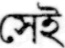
সেই
